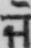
ਜੋ
